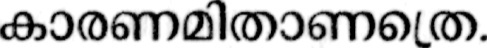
കാരണമിതാണത്രെ.
